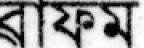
ৱাফম
